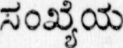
ಸಂಖ್ಯೆಯ
